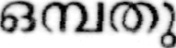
ഒമ്പതു
